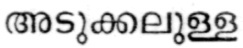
അടുക്കലുള്ള
